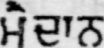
ਮੈਦਾਨ
